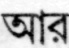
আর
